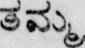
ತಮ್ಮ
